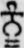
ਨੂੰ
